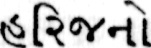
હરિજનો
